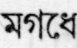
মগধে
